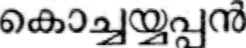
കൊച്ചയ്യപ്പന്‍
